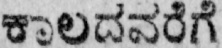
ಕಾಲದವರೆಗೆ
